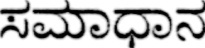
ಸಮಾಧಾನ
